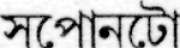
সপোনটো
